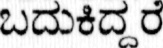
ಬದುಕಿದ್ದರೆ
